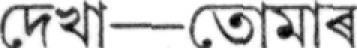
দেখা-তোমাৰ
